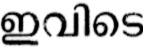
ഇവിടെ
